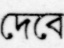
দেবে
